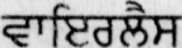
ਵਾਇਰਲੈਸ
